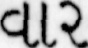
વાર
